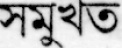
সমুখত
